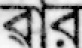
ৱার
